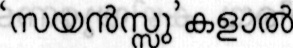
'സയന്‍സ്സു'കളാല്‍
